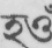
হওঁ
